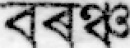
বৰঞ্চ
